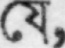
যে,
